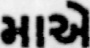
માએ
